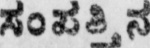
ಸ೦ಪತ್ತಿನ
